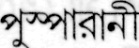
পুস্পারানী
